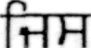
ਜਿਸ
